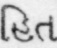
હિત
